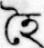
হৈ
